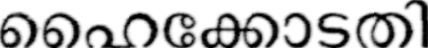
ഹൈക്കോടതി
